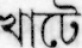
খাটে
